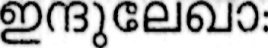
ഇന്ദുലേഖാ:
